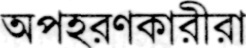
অপহরণকারীরা
